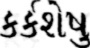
કર્કશેષુ
